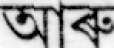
আৰু
